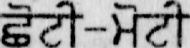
ਛੋਟੀ-ਮੋਟੀ
